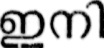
ഇനി
